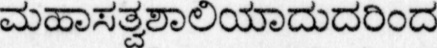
ಮಹಾಸತ್ವಶಾಲಿಯಾದುದರಿಂದ
